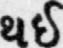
થઈ
